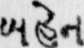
બહેન
